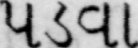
પડવા
